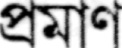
প্রমাণ
